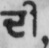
ਦੀ,
